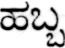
ಹಬ್ಬ
